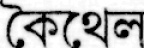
কৈথেল
